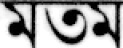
মতম
